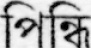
পিন্ধি
